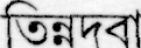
তিন্নদবা
